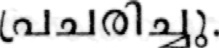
പ്രചരിച്ചു.
